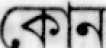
কোন
